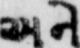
અને
